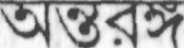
অন্তরঙ্গ
